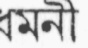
ধমনী
